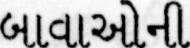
બાવાઓની
